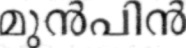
മുന്‍പിന്‍
